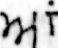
ਆਂ
